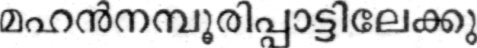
മഹന്‍നമ്പൂരിപ്പാട്ടിലേക്കു
